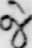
જે
